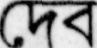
দেব
